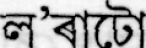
ল'ৰাটো
